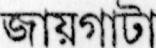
জায়গাটা
